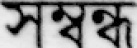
সম্বন্ধ
